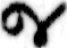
જ
